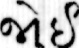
જોઈ
